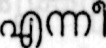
എന്നീ
